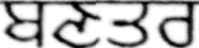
ਬਣਤਰ
